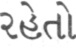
રહેતો
